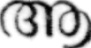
ആ
